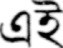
এই
